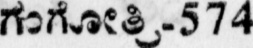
ಗಂಗೋತ್ರಿ-574
